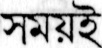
সময়ই
